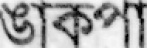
ঙাকপা
